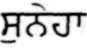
ਸੁਨੇਹਾ
